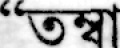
“তম্বা
